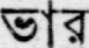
ভার
